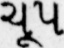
ચૂપ
